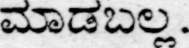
ಮಾಡಬಲ್ಲ.
